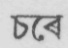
চৰে
